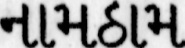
નામઠામ
